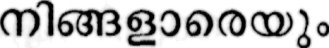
നിങ്ങളാരെയും
